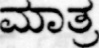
ಮಾತ್ರ
